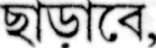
ছাড়াবে,
